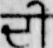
ਦੀ
